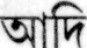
আদি
